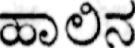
ಹಾಲಿನ
